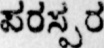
ಪರಸ್ಪರ
